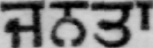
ਜਨਤਾ
